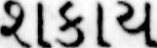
શકાય
